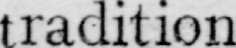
tradition
